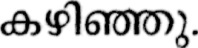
കഴിഞ്ഞു.
